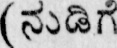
(ನುಡಿಗೆ
